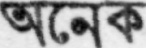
অনেক
